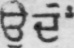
ਉਦੋਂ
